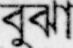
বুঝা
